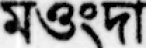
মওংদা
